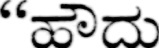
"ಹೌದು
